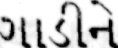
ગાડીને
